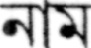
নাম
